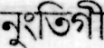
নুংতিগী
